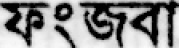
ফংজবা
